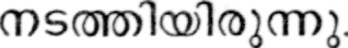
നടത്തിയിരുന്നു.
